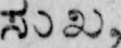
ಸುಖ,
